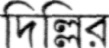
দিল্লির
